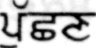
ਪੁੱਛਣ
